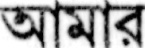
আমার
